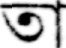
তা
